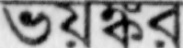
ভয়ঙ্কর
